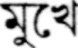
মুখে
